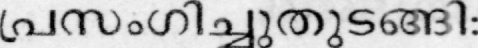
പ്രസംഗിച്ചുതുടങ്ങി:
